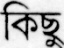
কিছু
